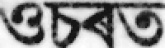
ওচৰত
